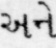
અને
